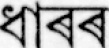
ধাৰৰ
